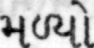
મળ્યો
